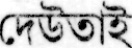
দেউতাই
